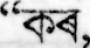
"কৰ,
